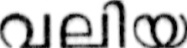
വലിയ
